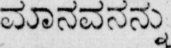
ಮಾನವನನ್ನು
